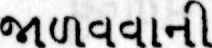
જાળવવાની
